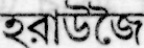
হরাউজৈ
